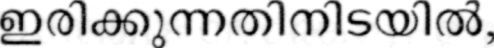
ഇരിക്കുന്നതിനിടയില്‍,
